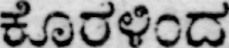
ಕೊರಳಿಂದ
